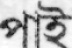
পাই
